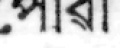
পোৱা
